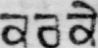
ਕਰਕੇ
